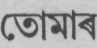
তোমাৰ
